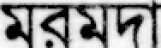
মরমদা
